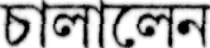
চালালেন
